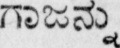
ಗಾಜನ್ನು
